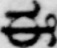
ಈ
